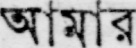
আমার
